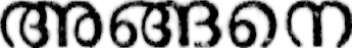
അങ്ങനെ
